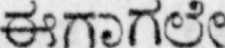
ಈಗಾಗಲೇ
